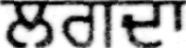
ਲਗਦਾ
